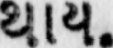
થાય.
